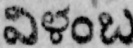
ವಿಳಂಬ
